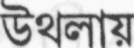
উথলায়
